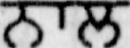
ਨਾਲ
